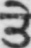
ਤੇ
